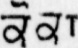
ਕੋਕਾ
